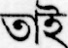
তাই
